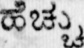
ಹೆಚ್ಚು
